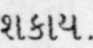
શકાય.
